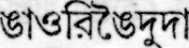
ঙাওরিঙৈদুদা
